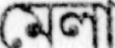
মেলা
